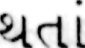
થતાં
